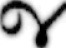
જ
